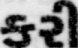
કરી
